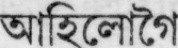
আহিলোগৈ
